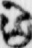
છે
